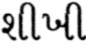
શીખી
